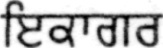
ਇਕਾਗਰ
